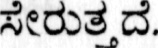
ಸೇರುತ್ತದೆ.
